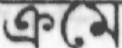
ক্রমে
